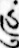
હું
